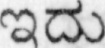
ಇದು
